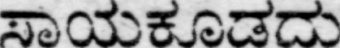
ಸಾಯಕೂಡದು
